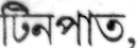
টিনপাত,
